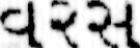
વરસ
